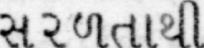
સરળતાથી
